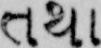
તથા
